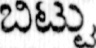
ಬಿಟ್ಟು
